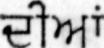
ਦੀਆਂ
